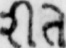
રીતે
